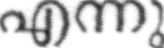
എന്നു
